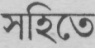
সহিতে
